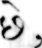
છે,
